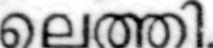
ലെത്തി.
